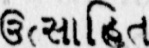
ઉત્સાહિત
